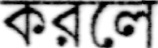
করলে
